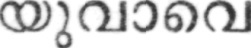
യുവാവെ
